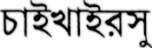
চাইখাইরসু
